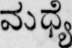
ಮಧ್ಯೆ
